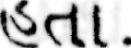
હતા.
